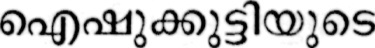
ഐഷുക്കുട്ടിയുടെ
